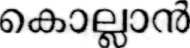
കൊല്ലാന്‍
